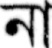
না
